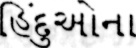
હિંદુઓના
